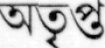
অতৃপ্ত
